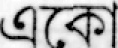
একো
